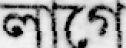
লাগে
